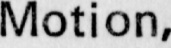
Motion,
